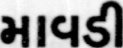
માવડી
